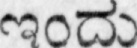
ಇಂದು
